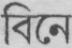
বিনে
